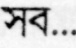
সব...
